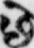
છે
